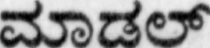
ಮಾಡಲ್
